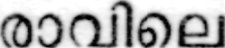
രാവിലെ
